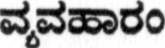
ವ್ಯವಹಾರ೦
